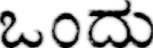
ಒಂದು
